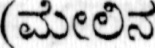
(ಮೇಲಿನ
